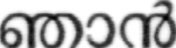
ഞാന്‍
